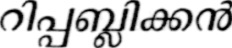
റിപ്പബ്ലിക്കന്‍
